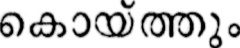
കൊയ്ത്തും
